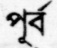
পূর্ব
